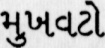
મુખવટો
